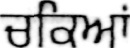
ਚਕਿਆਂ
